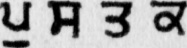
ਪੁਸਤਕ
